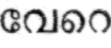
വേറെ
